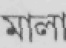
মালা
